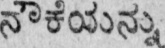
ನೌಕೆಯನ್ನು
